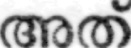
അത്
